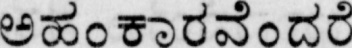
ಅಹಂಕಾರವೆಂದರೆ
